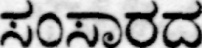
ಸಂಸಾರದ
